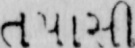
તપાસી
